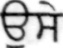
ਉਸੇ
